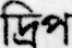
দ্রিপ
